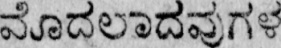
ಮೊದಲಾದವುಗಳ
